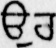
ਉਰ
